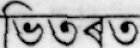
ভিতৰত
